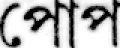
পোপ
